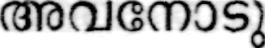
അവനോടു
